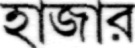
হাজার
